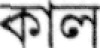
কাল
